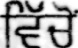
ਵਿੱਚੋਂ
